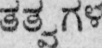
ತತ್ವಗಳ
